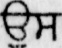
ਉਸ
